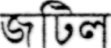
জটিল
